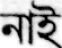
নাই
